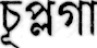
চূপ্লগা
